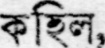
কহিল,
